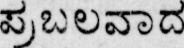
ಪ್ರಬಲವಾದ
